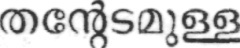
തന്റേടമുള്ള
